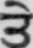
ਤੇ
